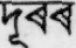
দূৰৰ
